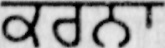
ਕਰਨਾ
